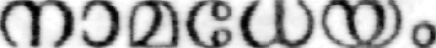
നാമധേയം
